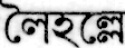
লৈহল্লে
